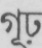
গূঢ়
